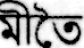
মীতৈ
